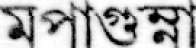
মপাগুম্না
